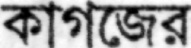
কাগজের
